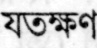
যতক্ষণ
